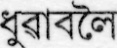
ধুৱাবলৈ
